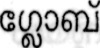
ഗ്ലോബ്
